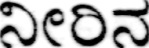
ನೀರಿನ
